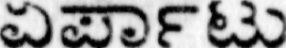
ಏರ್ಪಾಟು
